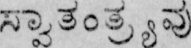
ಸ್ವಾತಂತ್ರ್ಯವು
